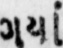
ગયાં
